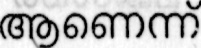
ആണെന്ന്
